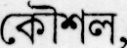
কৌশল,
